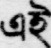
এই
